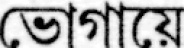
ভোগায়ে
